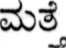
ಮತ್ತೆ
